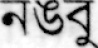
নঙবু
